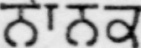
ਨਾਨਕ
